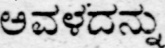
ಅವಳದನ್ನು
